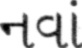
નવાં
